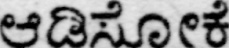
ಆಡಿಸೋಕೆ
